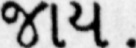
જાય.
